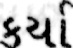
કર્યા
